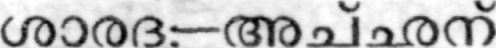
ശാരദ:-അച്ഛന്
